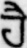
ਹੈ
